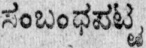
ಸಂಬಂಧಪಟ್ಟ
